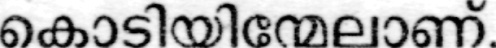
കൊടിയിന്മേലാണ്.
